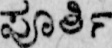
ಪೂರ್ತಿ
